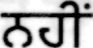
ਨਹੀਂ
